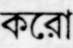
করো
